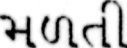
મળતી
